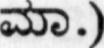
ಮಾ)
